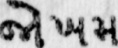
જોખમ
